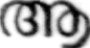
ആ
